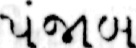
પંજાબ
